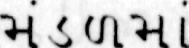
મંડળમાં
